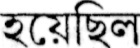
হয়েছিল
